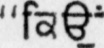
''ਕਿਉਂ
